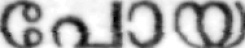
പോയ
